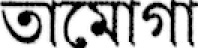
তামোগা
